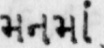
મનમાં
